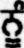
ਨੂੰ
